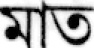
মাত
